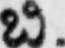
ಬಿ.
